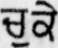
ਚੁਕੇ
